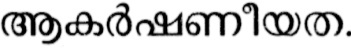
ആകര്‍ഷണീയത.
